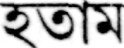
হতাম
